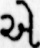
એ
